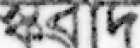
স্কৱাদ
